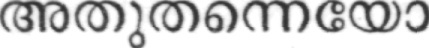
അതുതന്നെയോ
